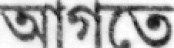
আগতে
